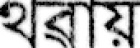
থৱায়
